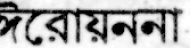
ঈরোয়ননা
